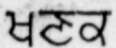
ਖਣਕ
